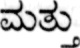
ಮತ್ತು
